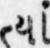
ત્યાં
